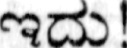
ಇದು!
